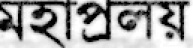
মহাপ্রলয়
